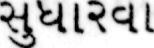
સુધારવા
